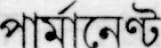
পার্মানেণ্ট
